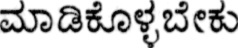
ಮಾಡಿಕೊಳ್ಳಬೇಕು
